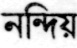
নন্দিয়
